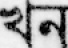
খন
